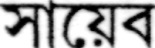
সায়েব
